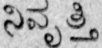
ನಿವೃತ್ತಿ
